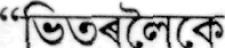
"ভিতৰলৈকে
